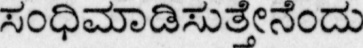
ಸಂಧಿಮಾಡಿಸುತ್ತೇನೆಂದು
